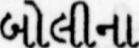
બોલીના
